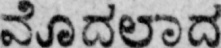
ಮೊದಲಾದ
